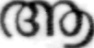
ആ
